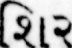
શિર
